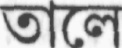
তালে
